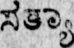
ಸತ್ಯಾ
